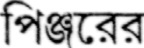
পিঞ্জরের
